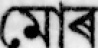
মোৰ
